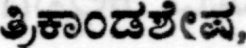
ತ್ರಿಕಾಂಡಶೇಷ,
